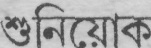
শুনিয়োক
